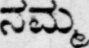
ನಮ್ಮ
